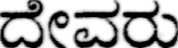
ದೇವರು
